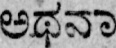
ಅಥವಾ
